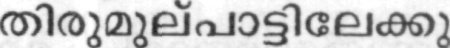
തിരുമുല്പാട്ടിലേക്കു
